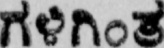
ಗಳಿಗಿಂತ
